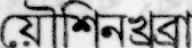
য়ৌশিনখ্রব্রা
